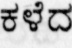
ಕಳೆದ
